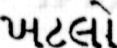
ખટલો
